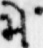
મેં
